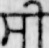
ਸੀ
